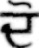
ਦੋ
